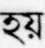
হয়
